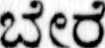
ಬೇರೆ
